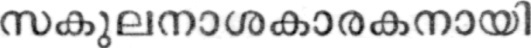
സകുലനാശകാരകനായി
